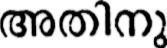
അതിനു
